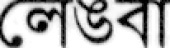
লেঙবা
